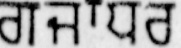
ਗਜਾਧਰ
